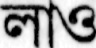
লাও
